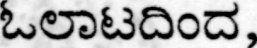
ಓಲಾಟದಿಂದ,
